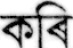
কৰি
